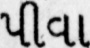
પીવા
